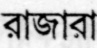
রাজারা
